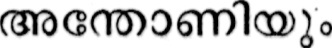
അന്തോണിയും
